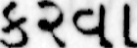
કરવા
